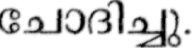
ചോദിച്ചു.
